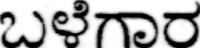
ಬಳೆಗಾರ
